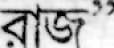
রাজ”
